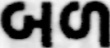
બળ
